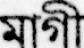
মাগী
